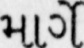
માર્ગે
